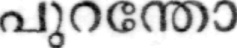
പുറന്തോ
